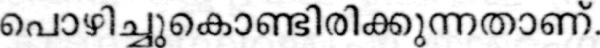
പൊഴിച്ചുകൊണ്ടിരിക്കുന്നതാണ്.
